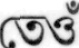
তেওঁ
